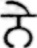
ਨੇ
